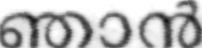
ഞാന്‍
